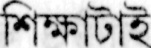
শিক্ষাটাই
